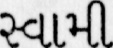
સ્વામી
